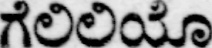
ಗೆಲಿಲಿಯೊ
